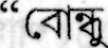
“বোন্ধু
